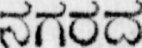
ನಗರದ
